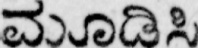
ಮೂಡಿಸಿ
